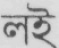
লই
